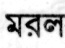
মরল
